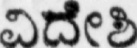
ವಿದೇಶಿ
